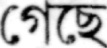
গেছে
